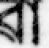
ৱা
